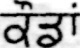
ਕੌਡਾਂ
